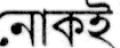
নোকই
